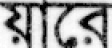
য়ারে
